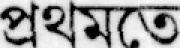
প্রথমতে
